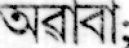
অৱাবা;
